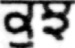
ਕੁਝ
